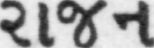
રાજન
